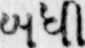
બધી
